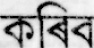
কৰিব
